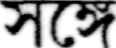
সঙ্গে
